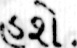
હશે.
